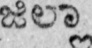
ಜಿಲ್ಲಾ
